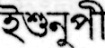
ইশুনুপী
